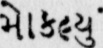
મોકલ્યું
